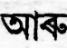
আৰু
